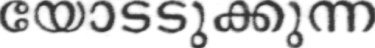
യോടടുക്കുന്ന
